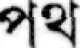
পথ
